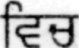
ਵਿਚ
